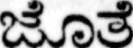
ಜೊತೆ
